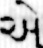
એ
